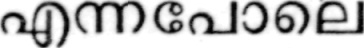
എന്നപോലെ
